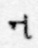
ન
